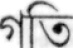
গতি
